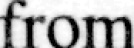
from
